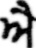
ਐ
